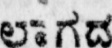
ಲಾಗದ
